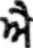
ਐ
